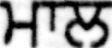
ਮਾਲ
